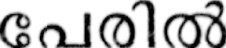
പേരില്‍
